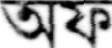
অফ
